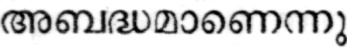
അബദ്ധമാണെന്നു
